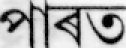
পাৰত
